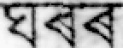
ঘৰৰ
